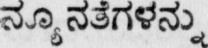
ನ್ಯೂನತೆಗಳನ್ನು
